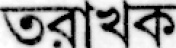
তরাখক
